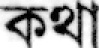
কথা
